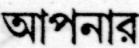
আপনার
